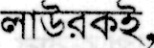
লাউরকই,
